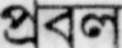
প্রবল
